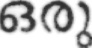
ഒരു
